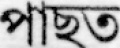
পাছত
